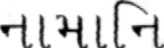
નામાનિ
